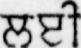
ਲਈ
